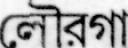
লৌরগা
